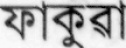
ফাকুৱা
